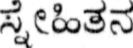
ಸ್ನೇಹಿತನ
